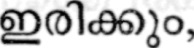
ഇരിക്കും,
